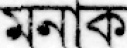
মনাক
